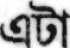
এটা
